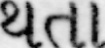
થતા
